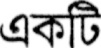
একটি
